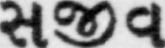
સજીવ
